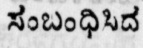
ಸಂಬಂಧಿಸಿದ
